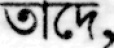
তাদে,
